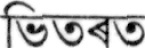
ভিতৰত
